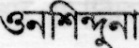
ওনশিন্দুনা
